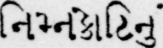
નિમ્નકોટિનું
